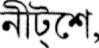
নীট্‌শে,
